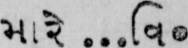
મારે...વિ
